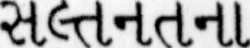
સલ્તનતના
